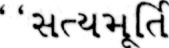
"સત્યમૂર્તિ
